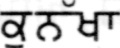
ਕੁਨੱਖਾ
